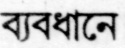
ব্যবধানে
